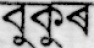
বুকুৰ
